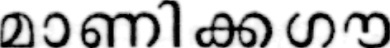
മാണിക്കഗൌ
